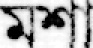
মশা
